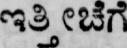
ಇತ್ತೀಚೆಗೆ
